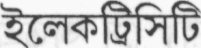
ইলেকট্রিসিটি
